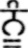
ਨੂੰ
